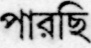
পারছি
